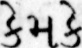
કેમકે
